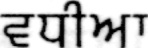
ਵਧੀਆ
